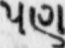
પણ
